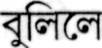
বুলিলে
